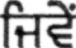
ਜਿਵੇਂ
